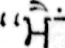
''ਮੈਂ
